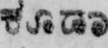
ಕೂಡಾ
